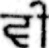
ਵੀ
